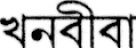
খনবীবা
